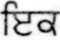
ਇਕ
